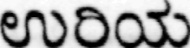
ಉರಿಯ
